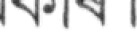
প্ৰকাৰ
